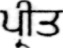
ਪ੍ਰੀਤ
